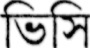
ভিসি
